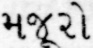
મજૂરો
